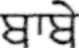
ਬਾਬੇ
